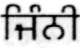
ਜਿੰਨੀ
